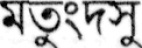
মতুংদসু
